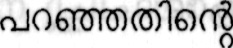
പറഞ്ഞതിന്റെ
